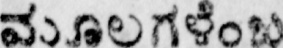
ಮೂಲಗಳೆಂಬ
